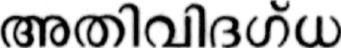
അതിവിദഗ്ധ
